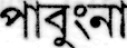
পাবুংনা
